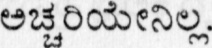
ಅಚ್ಚರಿಯೇನಿಲ್ಲ.
